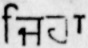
ਜਿਹਾ
